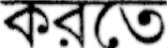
করতে
